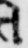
તે
